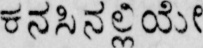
ಕನಸಿನಲ್ಲಿಯೇ
